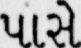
પાસે
